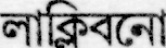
লাক্লিবনো
